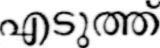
എടുത്ത്
